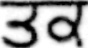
ਤਕ
